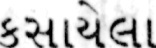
કસાયેલા
